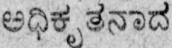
ಅಧಿಕೃತನಾದ
